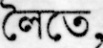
লৈতে,
